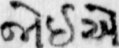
જોઈએ
